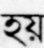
হয়
